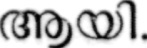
ആയി.
